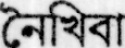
নৈখিবা
